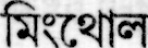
মিংথোল
